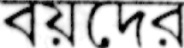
বয়দের
